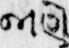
જાણે
